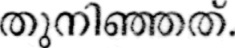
തുനിഞ്ഞത്.
